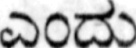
ಎಂದು
